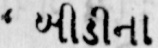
'બીડીના
